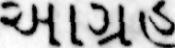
આગ્રહ
